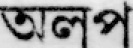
অলপ
